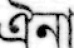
ঐনা
